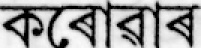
কৰোৱাৰ
